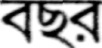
বছর
